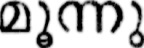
മൂന്നു
